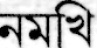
নমখি
